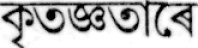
কৃতজ্ঞতাৰে
